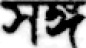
সঙ্গ
